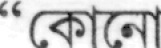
"কোনো
